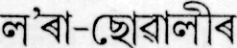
ল'ৰা-ছোৱালীৰ
